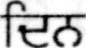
ਦਿਨ
